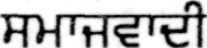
ਸਮਾਜਵਾਦੀ
